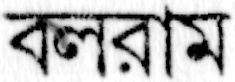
বলরাম
